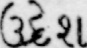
ઉદેશ
